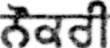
ਨੌਕਰੀ
